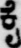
ಕೈ
